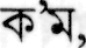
ক'ম,
